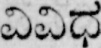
ವಿವಿಧ
